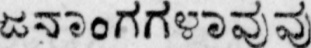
ಜನಾಂಗಗಳಾವುವು
